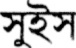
সুইস
